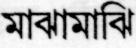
মাঝামাঝি
